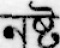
নষ্ট
